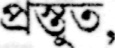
প্রস্তুত,
